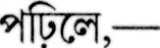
পঢ়িলে,-
